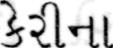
કેરીના
